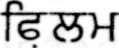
ਫ਼ਿਲਮ
